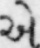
એ
